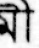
মী
